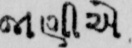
જાણીએ
